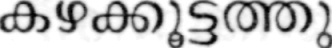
കഴക്കൂട്ടത്തു
